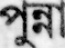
পুন্না
